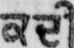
ਕਦੀ
